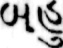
બહુ
